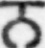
ਨ
